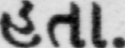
હતા.
